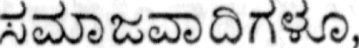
ಸಮಾಜವಾದಿಗಳೂ,
